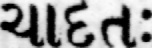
ચાદતઃ
